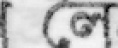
নত্তে
